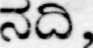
ನದಿ,
